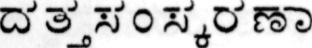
ದತ್ತಸಂಸ್ಕರಣಾ
